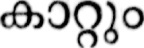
കാറ്റും
